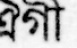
ঐগী
